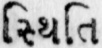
સ્થિતિ
